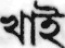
খাই
